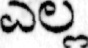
ಎಲ್ಲ
